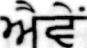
ਐਵੇਂ
